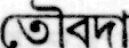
তৌবদা
